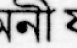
অনী
